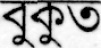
বুকুত
